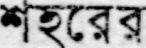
শহরের
